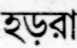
হড়রা
